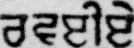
ਰਵਈਏ
